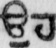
ਉਹ
